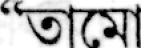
“তামো
